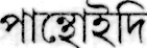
পান্থোইদি
